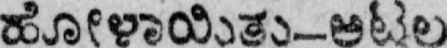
ಹೋಳಾಯಿತು-ಅಟಲ
